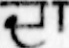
ਦਾ
